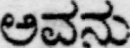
ಅವನು
